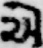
એ
